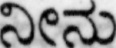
ನೀನು
